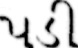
પડી
